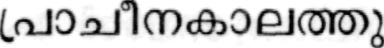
പ്രാചീനകാലത്തു
